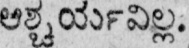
ಆಶ್ಚರ್ಯವಿಲ್ಲ.
